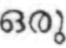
ഒരു
